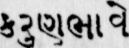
કરુણભાવે
